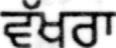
ਵੱਖਰਾ
